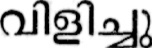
വിളിച്ചു
